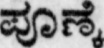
ಪೂಣ್ಕೆ
